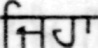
ਜਿਹਾ
